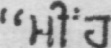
''ਮੀਂਹ
